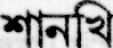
শানখি
